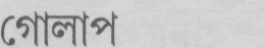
গোলাপ
